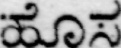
ಹೊಸ
